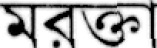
মরক্তা
